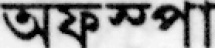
অফস্পা
